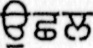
ਉਛਲ
